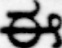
ಈ
